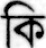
কি
